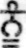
ਨੂੰ
